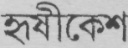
হৃষীকেশ
